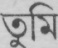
তুমি
